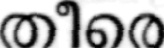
തീരെ
